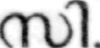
സി.
